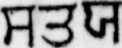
ਸਤਯ
